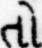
તો
